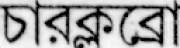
চারক্লব্রো
